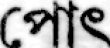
পোৎ
